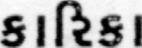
કારિકા
